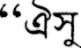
“ঐসু
